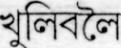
খুলিবলৈ
